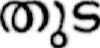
തുട
